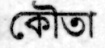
কৌতা
